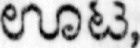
ಊಟ,
